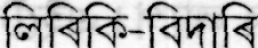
লিৰিকি-বিদাৰি
